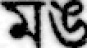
মঙ
